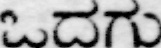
ಒದಗು
